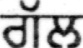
ਗੱਲ
